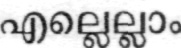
എല്ലെല്ലാം
